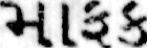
માફક
